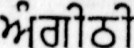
ਅੰਗੀਠੀ
